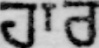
ਹਾਰ
